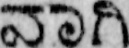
ವಾಗಿ
